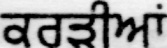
ਕਰੜੀਆਂ
